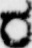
ರ
